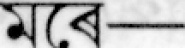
মৰে-
